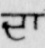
ਦਾ
